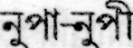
নুপা-নুপী
